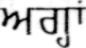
ਅਗ੍ਹਾਂ
